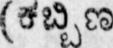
(ಕಬ್ಬಿಣ
